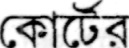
কোর্টের
